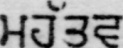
ਮਹੱਤਵ
